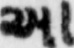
આ
